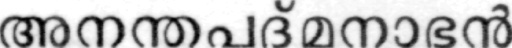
അനന്തപദ്മനാഭന്‍
